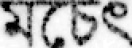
মচেৎ
